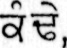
ਕੰਢੇ,
